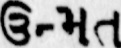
ઉન્મત
